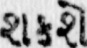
શકશે
